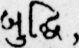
બુદ્ધિ,
